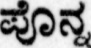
ಪೊನ್ನ
